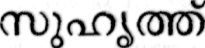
സുഹൃത്ത്
